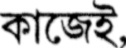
কাজেই,
